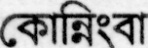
কোন্নিংবা
